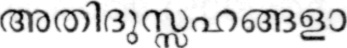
അതിദുസ്സഹങ്ങളാ
